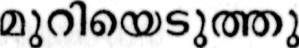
മുറിയെടുത്തു
